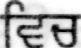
ਵਿਚ
